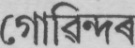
গোৱিন্দৰ
